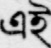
এই
